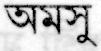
অমসু
